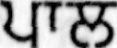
ਪਾਲ
